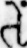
તેં
